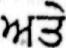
ਅਤੇ
